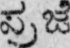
ಪ್ರಜೆ
